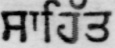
ਸਾਹਿੱਤ
